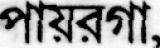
পায়রগা,
